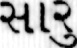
સારુ
